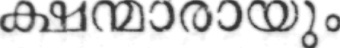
ക്ഷന്മാരായും
